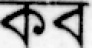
কব
